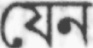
যেন
